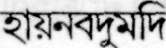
হায়নবদুমদি
